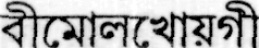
বীমোলখোয়গী
